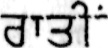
ਰਾਤੀਂ
